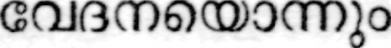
വേദനയൊന്നും
